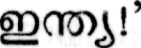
ഇന്ത്യ!’
